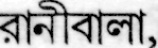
রানীবালা,
